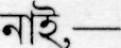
নাই,-
